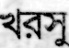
খরসু
